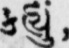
કહ્યું,
